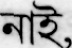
নাই,
